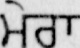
ਮੇਰਾ
